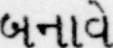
બનાવે
